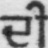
ਦੀ
